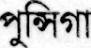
পুন্সিগা
